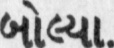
બોલ્યા.
